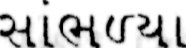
સાંભળ્યા
